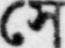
সে
